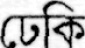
ঢেকি
